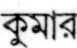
কুমার
